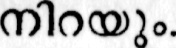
നിറയും.
